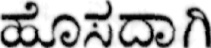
ಹೊಸದಾಗಿ
